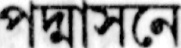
পদ্মাসনে
